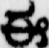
ಈ
